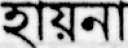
হায়না
